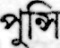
পুন্সি
